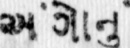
અંગોનું
